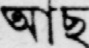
আছ
